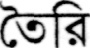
তৈরি
